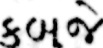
કબજે
